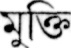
মুক্তি
